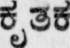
ಕೃತಕ
